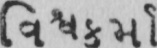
વિશ્વકર્મા
